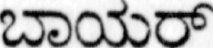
ಬಾಯರ್
